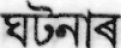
ঘটনাৰ
